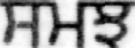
ਸਮਝ
